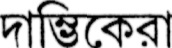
দাম্ভিকেরা
